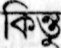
কিন্তু
